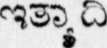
ಇತ್ಯಾದಿ
